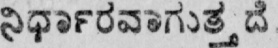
ನಿರ್ಧಾರವಾಗುತ್ತದೆ.
